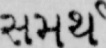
સમર્થ
